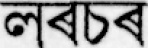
লৰচৰ
